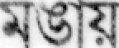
মঙায়
